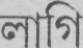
লাগি
